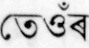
তেওঁৰ
